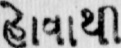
હોવાથી
